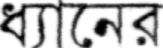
ধ্যানের
